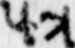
પત્ર
